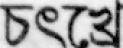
চৎখ্রে
